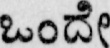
ಒಂದೇ
